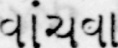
વાંચવા
